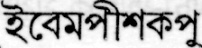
ইবেমপীশকপু
